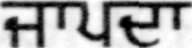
ਜਾਪਦਾ
